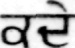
ਕਦੇ
